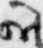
જો
